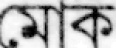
মোক
